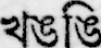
খঙঙি
